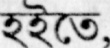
হইতে,
